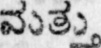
ಮತ್ತು
